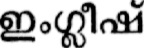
ഇംഗ്ലീഷ്
